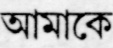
আমাকে
